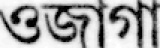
ওজাগা
